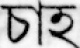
চাহ
